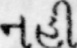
નહી
